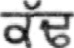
ਕੱਢ
